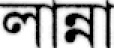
লান্না
